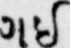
ગઈ
